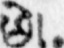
છો.
